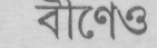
বীণেও
